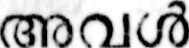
അവള്‍
